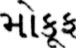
મોકૂફ
